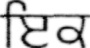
ਇਕ
